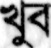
খুব
